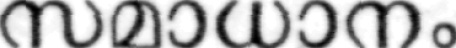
സമാധാനം
